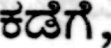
ಕಡೆಗೆ,
